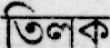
তিলক
